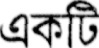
একটি
